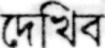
দেখিব
